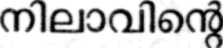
നിലാവിന്റെ
